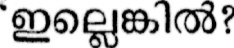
'ഇല്ലെങ്കില്‍?
